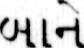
બાને
